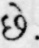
છે.
